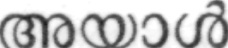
അയാള്‍
